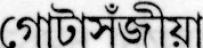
গোটাসঁজীয়া
